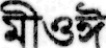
মীওঈ
